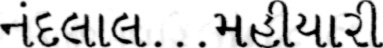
નંદલાલ...મહીયારી
